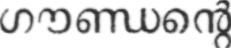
ഗൗണ്ഡന്റെ
